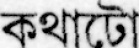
কথাটো
